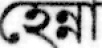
হেন্না
